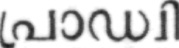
പ്രാഡ്വി
